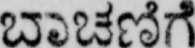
ಬಾಚಣಿಗೆ
